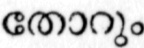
തോറും
